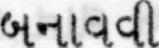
બનાવવી
